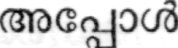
അപ്പോള്‍
